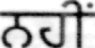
ਨਹੀਂ
